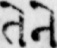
તેને
